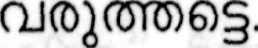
വരുത്തട്ടെ.
